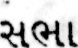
સભા
